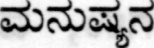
ಮನುಷ್ಯನ
